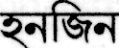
হনজিন
